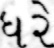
ધરે
